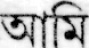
আমি
